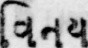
વિનય
